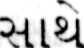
સાથે
